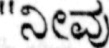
“ನೀವು
